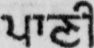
ਪਾਣੀ
